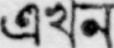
এখন
